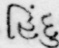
હિંદુ
